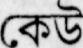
কেউ
